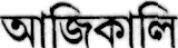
আজিকালি
